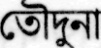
তৌদুনা
